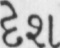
દેશ
